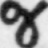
જ
